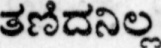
ತಣಿದನಿಲ್ಲ
